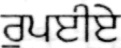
ਰੁਪਈਏ
